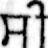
ਸੀ
